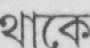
থাকে
